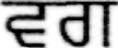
ਵਗ
